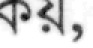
কয়,
